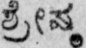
ಶ್ರೇಷ್ಠ
